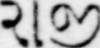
રાજી
